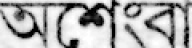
অশেংবা
